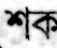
শক
